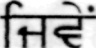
ਜਿਵੇਂ
